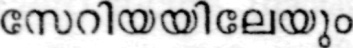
സേറിയയിലേയും
